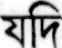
যদি
